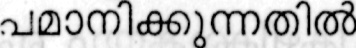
പമാനിക്കുന്നതില്‍
